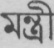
মন্ত্রী
